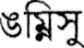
ঙম্নিসু
